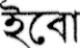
ইবো
